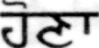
ਹੋਣਾ
